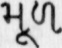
મૂળ
